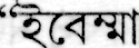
“ইবেম্মা
